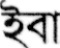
ঈবা
